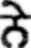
ਨੇ
